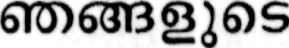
ഞങ്ങളുടെ
